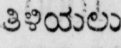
ತಿಳಿಯಲು
